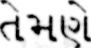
તેમણે
